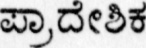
ಪ್ರಾದೇಶಿಕ
